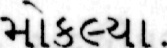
મોકલ્યા.
